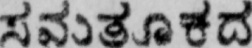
ಸಮತೂಕದ
